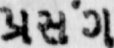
પ્રસંગ
